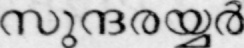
സുന്ദരയ്യര്‍
